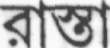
রাস্তা
